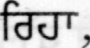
ਰਿਹਾ,
